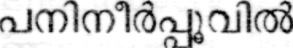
പനിനീര്‍പ്പൂവില്‍
